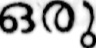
ഒരു
